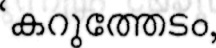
'കറുത്തേടം,
